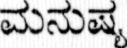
ಮನುಷ್ಯ
